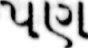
પણ
